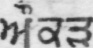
ਔਕੜ
